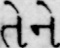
તેને
